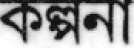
কল্পনা
